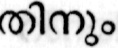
തിനും
